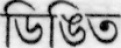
ডিঙিত
